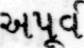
અપૂર્વ
